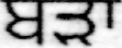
ਬੜਾ
